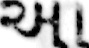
આ
